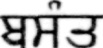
ਬਸੰਤ
